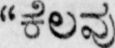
"ಕೆಲವು
